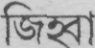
জিহ্বা
